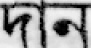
দান
